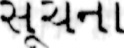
સૂચના
